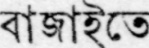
বাজাইতে
